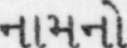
નામનો
